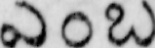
ಎಂಬ
